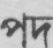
পদ
